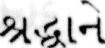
શ્રદ્ધાને
